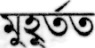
মুহূর্তত
